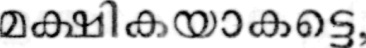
മക്ഷികയാകട്ടെ,
